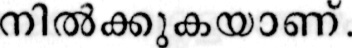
നില്‍ക്കുകയാണ്.
